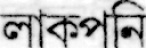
লাকপনি
